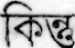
কিন্তু
